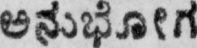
ಅನುಭೋಗ
